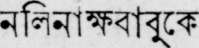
নলিনাক্ষবাবুকে
